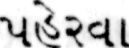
પહેરવા
